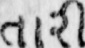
તારી
